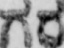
ಗರ
